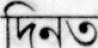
দিনত
